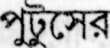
পুটুসের
